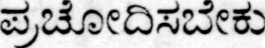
ಪ್ರಚೋದಿಸಬೇಕು
